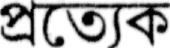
প্রত্যেক
